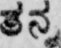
ತನ್ನ
